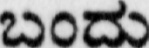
ಬಂದು
